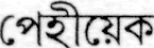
পেহীয়েক
